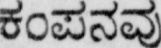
ಕಂಪನವು
